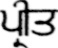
ਪ੍ਰੀਤ
